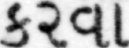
કરવા
